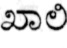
ಖಾಲಿ
